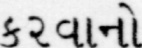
કરવાનો
